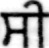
ਸੀ
